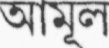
আমূল
